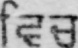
ਵਿਚ
